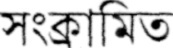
সংক্রামিত
